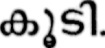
കൂടി.
